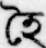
হৈ
